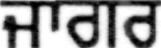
ਜਾਗਰ
